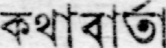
কথাবার্তা
